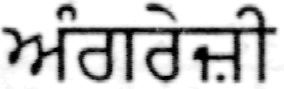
ਅੰਗਰੇਜ਼ੀ
